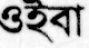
ওইবা
